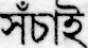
সঁচাই
